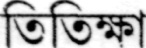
তিতিক্ষা
